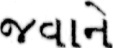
જવાને
